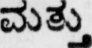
ಮತ್ತು
